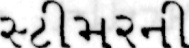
સ્ટીમરની
